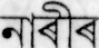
নাৰীৰ
